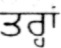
ਤਰ੍ਹਾਂ
